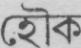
হৌকে
